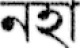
নহা
